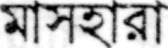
মাসহারা
